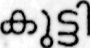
കുട്ടി
